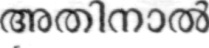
അതിനാല്‍
